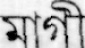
মাগী
